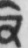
ਕੇ
